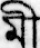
মী
